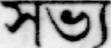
সভ্য
